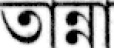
তম্না
